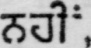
ਨਹੀਂ,
